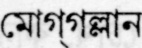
মোগ্গল্লান
